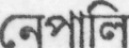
নেপালি
